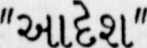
"આદેશ"
